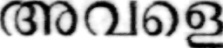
അവളെ
